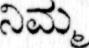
ನಿಮ್ಮ
